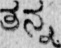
ತನ್ನ
